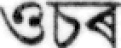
ওচৰ
